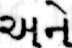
અને
